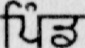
ਪਿੰਡ
